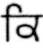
ਕਿ
